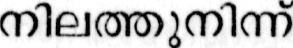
നിലത്തുനിന്ന്
